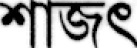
শাজৎ
